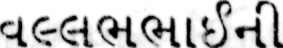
વલ્લભભાઈની
